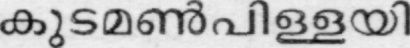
കുടമണ്‍പിള്ളയി
